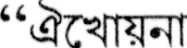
“ঐখোয়না
